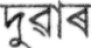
দুৱাৰ
